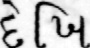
દેખિ
